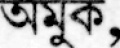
অমুক,
